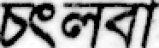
চৎলবা
